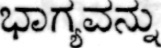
ಭಾಗ್ಯವನ್ನು
